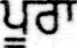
ਪੂਰਾ
